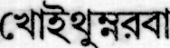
খোইথুম্নরবা
